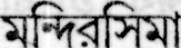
মন্দিরসিমা
